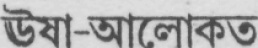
উষা-আলোকত
